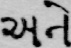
અને
